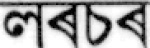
লৰচৰ
